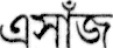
এসাঁজ
